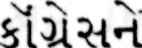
કૉંગ્રેસને
